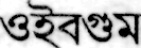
ওইবগুম
